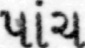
પાંચ
